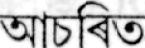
আচৰিত
